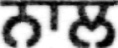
ਨਾਲ
